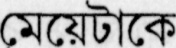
মেয়েটাকে
